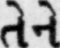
તેને
